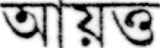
আয়ত্ত
